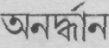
অনৰ্দ্ধান
